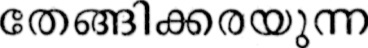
തേങ്ങിക്കരയുന്ന
